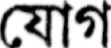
যোগ
